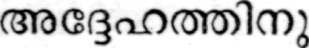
അദ്ദേഹത്തിനു
